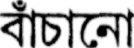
বাঁচানো
